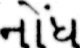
નોંધ
